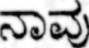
ನಾವು
